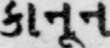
કાનૂન
